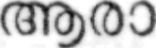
ആരാ
